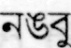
নঙবু
